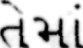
તેમાં
